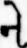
ને
